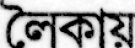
লৈকায়
